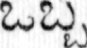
ಒಬ್ಬ
